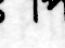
জিঃ
